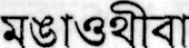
মঙাওথীবা
